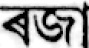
ৰজা
